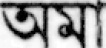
অমা
